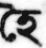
হৈ
